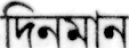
দিনমান
